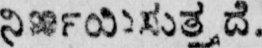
ನಿರ್ಣಯಿಸುತ್ತದೆ.
